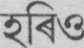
হৰিও
